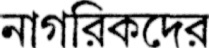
নাগরিকদের
